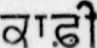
ਕਾਫ਼ੀ
